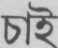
চাই
